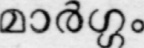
മാര്‍ഗ്ഗം
